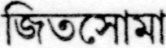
জিতসোমা
